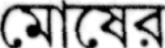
মোষের
